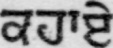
ਕਹਾਏ
